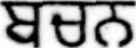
ਬਚਨ
